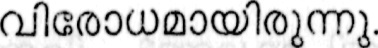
വിരോധമായിരുന്നു.
